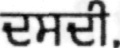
ਦਸਦੀ,
